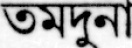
তমদুনা
